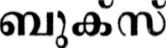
ബുക്സ്
